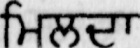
ਮਿਲਦਾ
